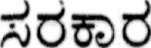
ಸರಕಾರ
